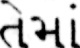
તેમાં
